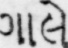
ગાલે
